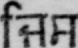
ਜਿਸ
